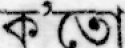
ক'তো
